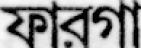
ফারগা
